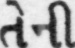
તેની
